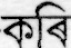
কৰি
